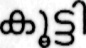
കൂട്ടി
